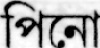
পিনো
